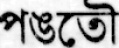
পঙতৌ
